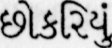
છોકરિયું
